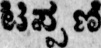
ಟಿಪ್ಪಣಿ
